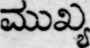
ಮುಖ್ಯ
